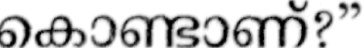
കൊണ്ടാണ്?”
